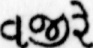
વજીરે
